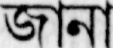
জানা
